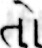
તો
